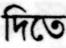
দিতে
